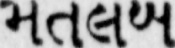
મતલબ
